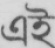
এই
